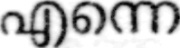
എന്നെ
